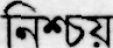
নিশ্চয়
